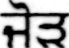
ਜੋੜ
